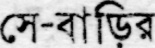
সে-বাড়ির
